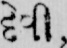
દેવી,
